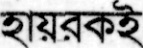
হায়রকই
